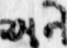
અને
